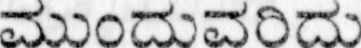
ಮುಂದುವರಿದು
